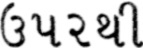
ઉપરથી
